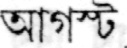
আগস্ট
